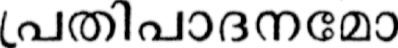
പ്രതിപാദനമോ
